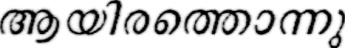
ആയിരത്തൊന്നു
